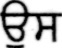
ਉਸ
